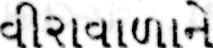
વીરાવાળાને
